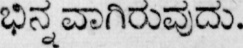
ಭಿನ್ನವಾಗಿರುವುದು.
